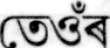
তেওঁৰ
